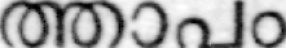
ത്താപം
